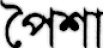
পৈশা
